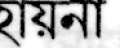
হায়না
